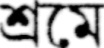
শ্রমে
